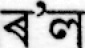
ৰ'ল
